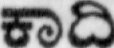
ಕಾದಿ
